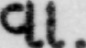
વા.
